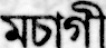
মচাগী
